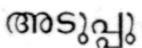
അടുപ്പു
